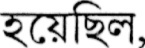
হয়েছিল,
